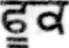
ਫੂਕ
